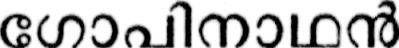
ഗോപിനാഥന്‍
